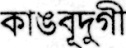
কাঙবূদুগী
